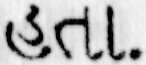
હતા.
